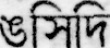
ঙসিদি
